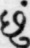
છું
